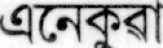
এনেকুৱা
